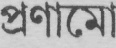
প্ৰণামো
